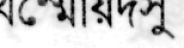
থম্মোয়দসু
